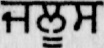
ਜਲੂਸ
